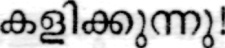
കളിക്കുന്നു!
